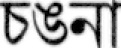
চঙনা
